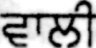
ਵਾਲੀ
